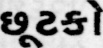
છૂટકો
